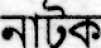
নাটক
